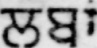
ਲਬਾਂ
